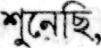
শুনেছি,
